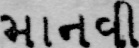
માનવી
